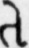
તે
